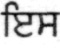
ਇਸ
